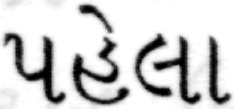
પહેલા
